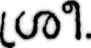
ശ്രീ.
